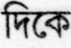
দিকে
